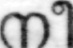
നീ
